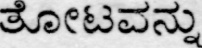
ತೋಟವನ್ನು
